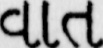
વાત
